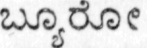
ಬ್ಯೂರೋ
